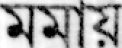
মমায়
